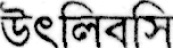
উৎলিবসি
